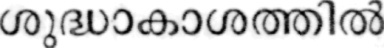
ശുദ്ധാകാശത്തില്‍
